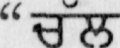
''ਚੱਲ
